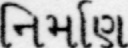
નિર્માણ
